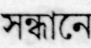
সন্ধানে
